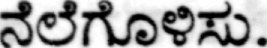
ನೆಲೆಗೊಳಿಸು.
